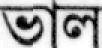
ভাল
